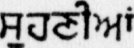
ਸੁਹਣੀਆਂ
